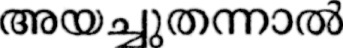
അയച്ചുതന്നാല്‍
